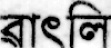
ৱাৎলি
